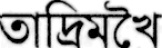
তাদ্রিমখৈ
